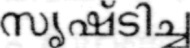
സൃഷ്ടിച്ച
